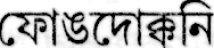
ফোঙদোক্কনি
